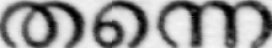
തന്നെ
